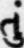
તું
